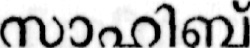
സാഹിബ്
